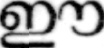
ഈ
